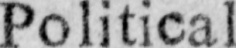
Political
